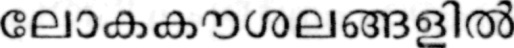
ലോകകൌശലങ്ങളില്‍
